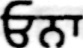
ਓਨਾ
